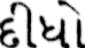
દીધો
